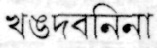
খঙদবনিনা
